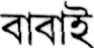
বাবাই
